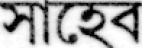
সাহেব
